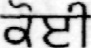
ਕੋਈ
